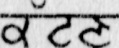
ਕੱਟਣ
